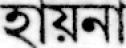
হায়না
